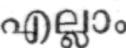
എല്ലാം
